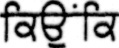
ਕਿਉਂਕਿ
